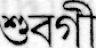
শুবগী
